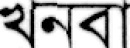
খনবা
